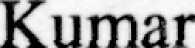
Kumar
